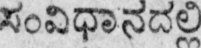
ಸಂವಿಧಾನದಲ್ಲಿ
